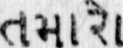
તમારો
